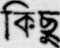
কিছু
